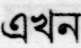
এখন
